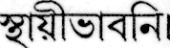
স্থায়ীভাবনি।
